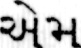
એમ
